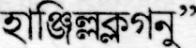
হাঞ্জিল্লক্লগনু”
